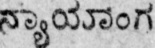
ನ್ಯಾಯಾಂಗ
